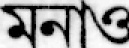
মনাও
